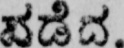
ಪಡೆದ.
